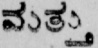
ಮತ್ತು
